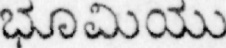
ಭೂಮಿಯು
